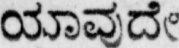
ಯಾವುದೇ
